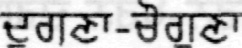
ਦੁਗਣਾ-ਚੋਗੁਣਾ
